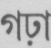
গঢ়া
